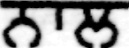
ਨਾਲ
